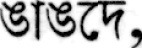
ঙাঙদে,
